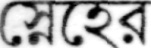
স্নেহের
